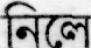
নিলে
